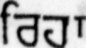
ਰਿਹਾ
